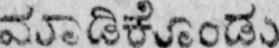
ಮಾಡಿಕೊಂಡು
